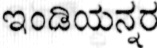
ಇಂಡಿಯನ್ನರ
